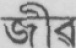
জীৱ
